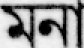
মনা
